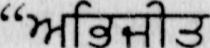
''ਅਭਿਜੀਤ
